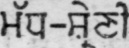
ਮੱਧ-ਸ਼੍ਰੇਣੀ
